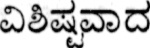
ವಿಶಿಷ್ಟವಾದ
